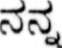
ನನ್ನ
